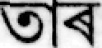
তাৰ
